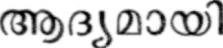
ആദ്യമായി
